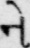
ને
